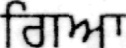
ਗਿਆ
